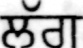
ਲੱਗ
